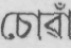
চোৱাঁ
